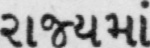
રાજ્યમાં
